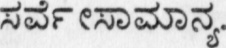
ಸರ್ವೇಸಾಮಾನ್ಯ.
